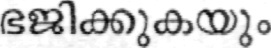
ഭജിക്കുകയും
